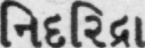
નિદરિદ્રા
